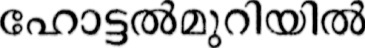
ഹോട്ടല്‍മുറിയില്‍
